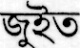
জুইত
